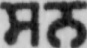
ਸਨ
